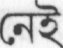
নেই
